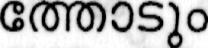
ത്തോടും
